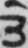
ਤੇ
